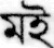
মই
